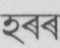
হৰৰ
